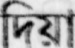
দিয়া
